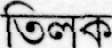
তিলক
